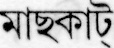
মাছকাট্
